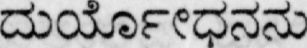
ದುರ್ಯೋಧನನು
